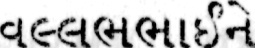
વલ્લભભાઈને
